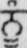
ਨੂੰ
